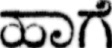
ಹಾಗೆ
